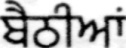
ਬੈਠੀਆਂ
